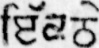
ਇੱਕਠੇ
